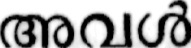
അവള്‍
